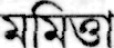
মমিত্তা
